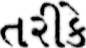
તરીકે
